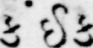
કંઈક
